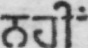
ਨਹੀਂ
